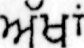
ਅੱਖਾਂ
